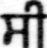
ਸੀ
